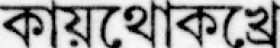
কায়থোকখ্রে
